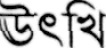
ঊৎখি
